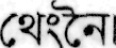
থেংনৈ।
